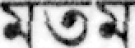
মতম
